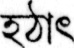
হঠাৎ
